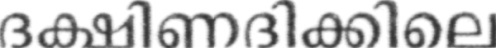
ദക്ഷിണദിക്കിലെ
